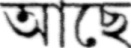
আছে
